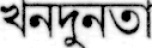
খনদুনতা
